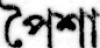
পৈশা
